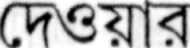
দেওয়ার
